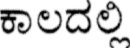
ಕಾಲದಲ್ಲಿ
